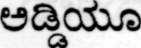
ಅಡ್ಡಿಯೂ
